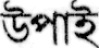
উপাই
